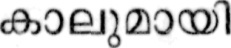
കാലുമായി
